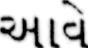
આવે
